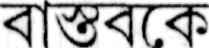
বাস্তবকে
